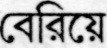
বেরিয়ে
